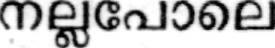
നല്ലപോലെ
